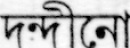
দন্দীনো
